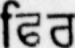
ਫਿਰ
